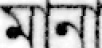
মানা
